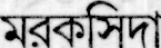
মরকসিদা
